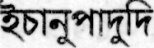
ইচানুপাদুদি
